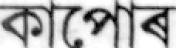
কাপোৰ
